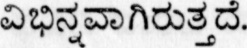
ವಿಭಿನ್ನವಾಗಿರುತ್ತದೆ.
